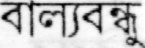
বাল্যবন্ধু
